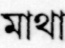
মাথা
